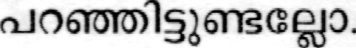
പറഞ്ഞിട്ടുണ്ടല്ലോ.
